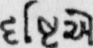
દ્દષ્ટિએ
